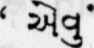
'એવું
